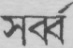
সৰ্ব্ব
